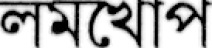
লমখোপ
